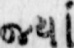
જ્યાં
